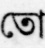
তো
